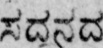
ಸದನದ
